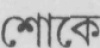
শোকে
